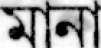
মানা
